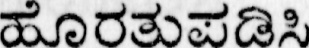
ಹೊರತುಪಡಿಸಿ
